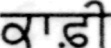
ਕਾਫ਼ੀ
